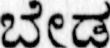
ಬೇಡ
